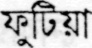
ফুটিয়া
